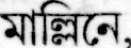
মাল্লিনে,
